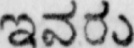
ಇವರು
